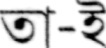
তা-ই
